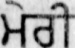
ਮੇਰੀ
